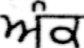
ਅੰਕ
